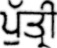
ਪੁੱਤ੍ਰੀ
